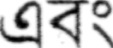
এবং
